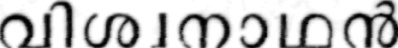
വിശ്വനാഥന്‍
